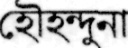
হৌহন্দুনা
